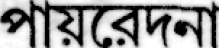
পায়রেদনা
